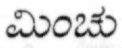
ಮಿಂಚು
